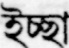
ইচ্ছা
